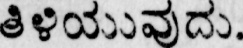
ತಿಳಿಯುವುದು.
